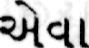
એવા
